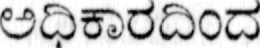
ಅಧಿಕಾರದಿಂದ
